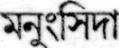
মনুংসিদা
